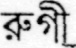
রুগী
